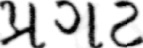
પ્રગટ
